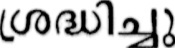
ശ്രദ്ധിച്ചു
